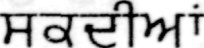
ਸਕਦੀਆਂ
